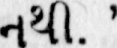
નથી.'
